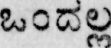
ಒಂದಲ್ಲ
